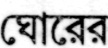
ঘোরের
